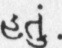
હતું.
